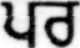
ਪਰ
